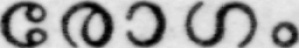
രോഗം
